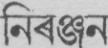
নিৰঞ্জন
